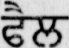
ਫੈਲ
